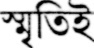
স্মৃতিই
